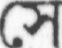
সে
